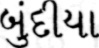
બુંદીયા
